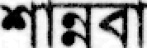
শান্নবা
